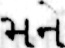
મને
